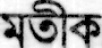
মতীক
